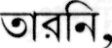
তারনি,
